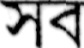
সব
